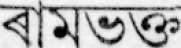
ৰামভক্ত
